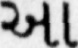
આ
